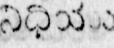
ನಿಧಿಯು
